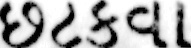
છટકવા
